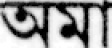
অমা
